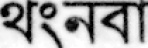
থংনবা
